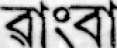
ৱাংবা
